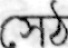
সেঠ
